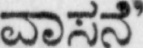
ವಾಸನೆ’
